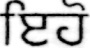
ਇਹੋ
